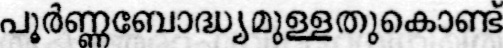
പൂര്‍ണ്ണബോദ്ധ്യമുള്ളതുകൊണ്ട്
